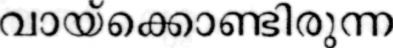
വായ്ക്കൊണ്ടിരുന്ന
